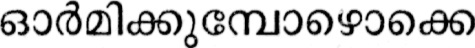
ഓര്‍മിക്കുമ്പോഴൊക്കെ
